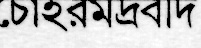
চোইরমদ্রবদি
